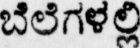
ಬೆಲೆಗಳಲ್ಲಿ
